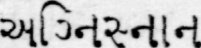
અગ્નિસ્નાન
